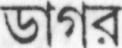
ডাগর
